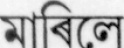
মাৰিলে
